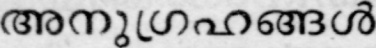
അനുഗ്രഹങ്ങള്‍
